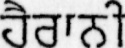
ਹੈਰਾਨ
